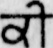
ਕੀ
